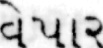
વેપાર
